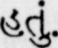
હતું.
